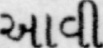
આવી
